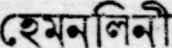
হেমনলিনী
